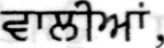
ਵਾਲੀਆਂ,
